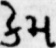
કેમ
